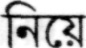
নিয়ে
